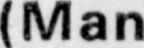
(Man
